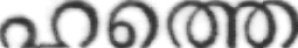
ഹത്തെ
